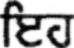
ਇਹ
